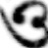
ও
